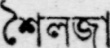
শৈলজা
